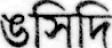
ঙসিদি
